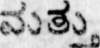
ಮತ್ತು
